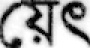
য়েৎ
